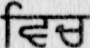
ਵਿਚ
